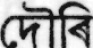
দৌৰি
